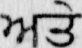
ਅਤੇ
